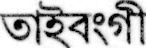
তাইবংগী
